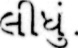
લીધું.
